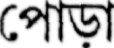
পোড়া
